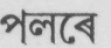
পলৰে
